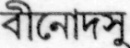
বীনোদসু
